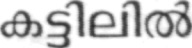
കട്ടിലില്‍
